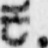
ಕ.
